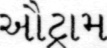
ઔટ્રામ
